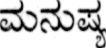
ಮನುಷ್ಯ
